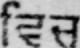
ਵਿਚ
